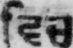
ਵਿਚ
